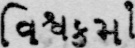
વિશ્વકર્મા
